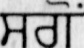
ਸਗੋਂ
